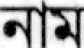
নাম
